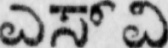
ಎಸ್‌ವಿ
